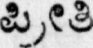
ಪ್ರೀತಿ
